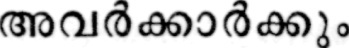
അവര്‍ക്കാര്‍ക്കും
